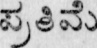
ಪ್ರತಿಮೆ
